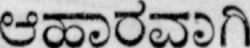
ಆಹಾರವಾಗಿ
